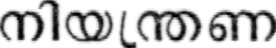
നിയന്ത്രണ
